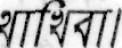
থাখিবা।
